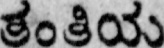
ತಂತಿಯ
